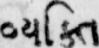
વ્યક્તિ
